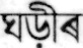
ঘড়ীৰ
